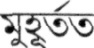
মুহূর্তত
